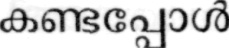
കണ്ടപ്പോള്‍
